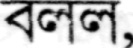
বলল,
